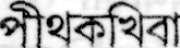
পীথকচখিবা
